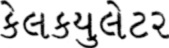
કેલક્યુલેટર
